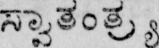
ಸ್ವಾತಂತ್ರ್ಯ
